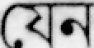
যেন
